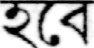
হবে
